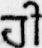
ਹੀ
